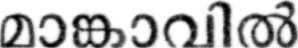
മാങ്കാവില്‍
